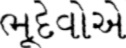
ભૂદેવોએ
